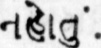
નહોતું.
